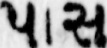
પાસ
